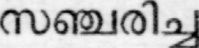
സഞ്ചരിച്ച
